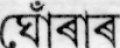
ঘোঁৰাৰ
